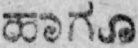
ಹಾಗೂ
